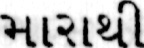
મારાથી
